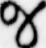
જ
